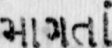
માગતાં
